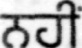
ਨਹੀਂ
